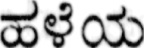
ಹಳೆಯ
